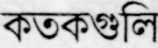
কতকগুলি
